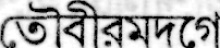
তৌবীরমদগে
